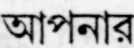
আপনার
